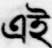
এই
